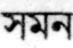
সমন
